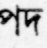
পদ
